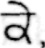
ਕੇ,
